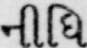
નીધિ
